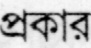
প্রকার
